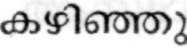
കഴിഞ്ഞു
